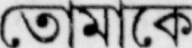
তোমাকে
